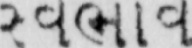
સ્વભાવ
